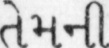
તેમની
